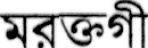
মরক্তগী
